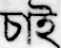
চাই
